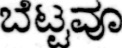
ಬೆಟ್ಟವೂ
